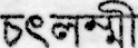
চৎলম্মী
